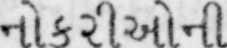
નોકરીઓની
